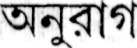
অনুরাগ
